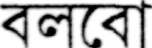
বলবো
